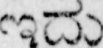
ಇದು
